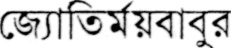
জ্যোতির্ময়বাবুর
